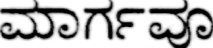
ಮಾರ್ಗವೂ
